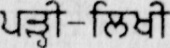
ਪੜ੍ਹੀ-ਲਿਖੀ
